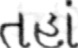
તહાં
